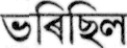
ভৰিছিল
